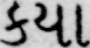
કયા
